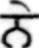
ਨੇ
